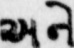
અને
